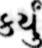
કર્યું
